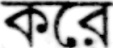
করে
